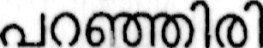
പറഞ്ഞിരി
